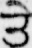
ਤੇ
